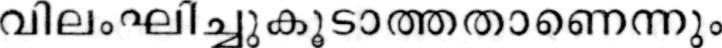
വിലംഘിച്ചുകൂടാത്തതാണെന്നും
